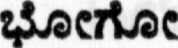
ಭೋಗೋ
